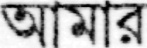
আমার
